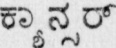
ಕ್ಯಾನ್ಸರ್
